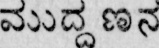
ಮುದ್ದಣನ
